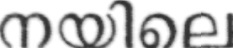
നയിലെ
